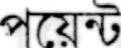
পয়েন্ট
